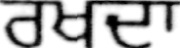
ਰਖਦਾ
